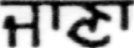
ਜਾਣਾ
